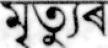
মৃত্যুৰ
